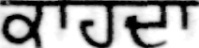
ਕਾਹਦਾ
